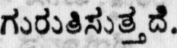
ಗುರುತಿಸುತ್ತದೆ.
